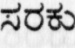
ಸರಕು
